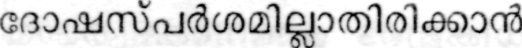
ദോഷസ്പര്‍ശമില്ലാതിരിക്കാന്‍
